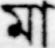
মা
